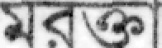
মরক্তা
